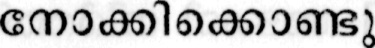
നോക്കിക്കൊണ്ടു
